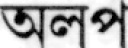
অলপ
